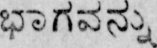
ಭಾಗವನ್ನು
